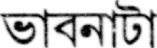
ভাবনাটা
